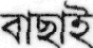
বাছাই
